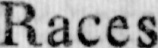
Races
